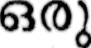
ഒരു
